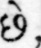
છે,
